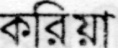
করিয়া
